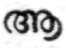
ആ
